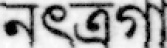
নৎত্রগা
